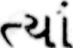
ત્યાં
